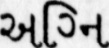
અગ્નિ
